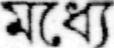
মধ্যে
